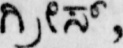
ಗ್ರೀಸ್,
